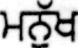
ਮਨੁੱਖ
